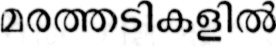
മരത്തടികളില്‍
